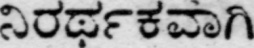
ನಿರರ್ಥಕವಾಗಿ
